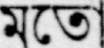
মতো
